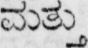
ಮತ್ತು
